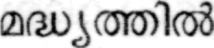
മദ്ധ്യത്തില്‍
